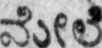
ಮೇಲೆ
